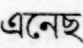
এনেছ
